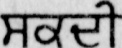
ਸਕਦੀ
